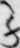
કે
